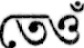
তেওঁ
